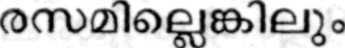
രസമില്ലെങ്കിലും
